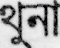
থুনা
